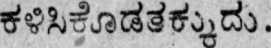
ಕಳಿಸಿಕೊಡತಕ್ಕುದು.
